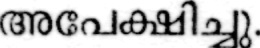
അപേക്ഷിച്ചു.
